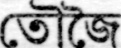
তৌজৈ
